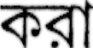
করা
